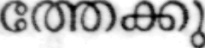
ത്തേക്കു
